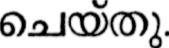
ചെയ്തു.
